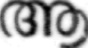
ആ
